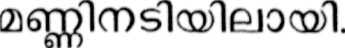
മണ്ണിനടിയിലായി.
